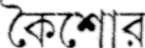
কৈশোর
